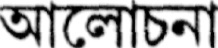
আলোচনা
